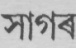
সাগৰ
